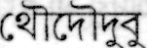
থৌদৌদুবু
